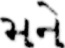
મને
